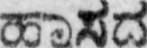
ಹಾಸದ
